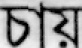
চায়
